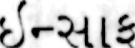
ઇન્સાફ
